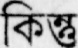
কিন্তু
